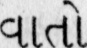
વાતો
